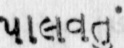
પાલવતું
